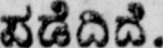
ಪಡೆದಿದೆ.
